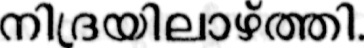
നിദ്രയിലാഴ്ത്തി.
